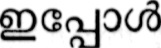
ഇപ്പോള്‍
